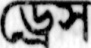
ড্রেস
